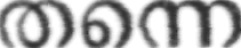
തന്നെ
